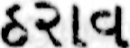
ઠરાવ
